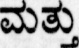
ಮತ್ತು
